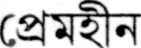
প্রেমহীন
